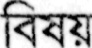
বিষয়
